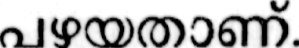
പഴയതാണ്.
